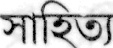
সাহিত্য
